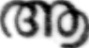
ആ
